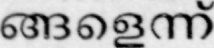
ങ്ങളെന്ന്
